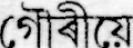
গৌৰীয়ে
